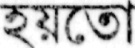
হয়তো
